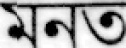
মনত
